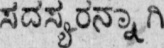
ಸದಸ್ಯರನ್ನಾಗಿ
